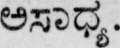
ಅಸಾಧ್ಯ.
